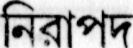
নিরাপদ
